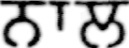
ਨਾਲ
